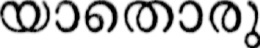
യാതൊരു
